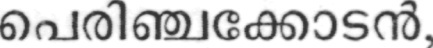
പെരിഞ്ചക്കോടന്‍,
